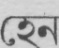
হেন
